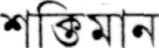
শক্তিমান
